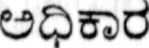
ಅಧಿಕಾರ
